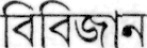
বিবিজান
